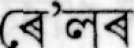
ৰে'লৰ
